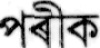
পৰীক
